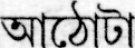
আঠোটা
